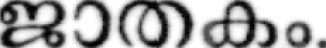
ജാതകം.
